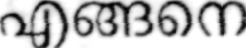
എങ്ങനെ
